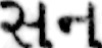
સન
